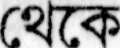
থেকে
